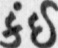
કંઈ
